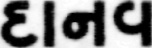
દાનવ
